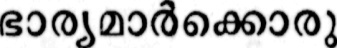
ഭാര്യമാര്‍ക്കൊരു
